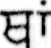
ਥਾਂ
